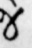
જે
